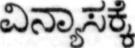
ವಿನ್ಯಾಸಕ್ಕೆ
